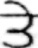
ਤੇ
